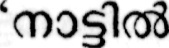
'നാട്ടില്‍
